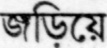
জড়িয়ে
